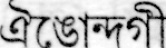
ঐঙোন্দগী
